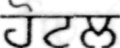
ਹੋਟਲ
